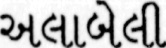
અલાબેલી
